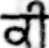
ਕੀ
